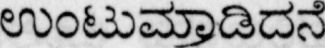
ಉಂಟುಮ್ರಾಡಿದನೆ
